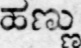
ಹಣ್ಣು
